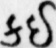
કઈ
